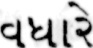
વધારે
